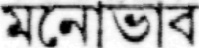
মনোভাব
